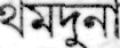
থমদুনা
